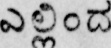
ಎಲ್ಲಿಂದ
